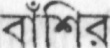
বাঁশির
